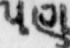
પણ
